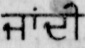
ਜਾਂਦੀ
